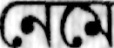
নেমে
